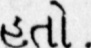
હતો.
